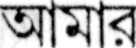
আমার
